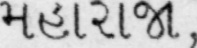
મહારાજા,
